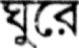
ঘুরে
